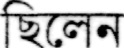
ছিলেন
